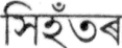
সিহঁতৰ
